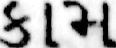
કામ
